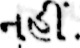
નહીં.
